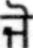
ਜੋ
